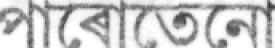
পাৰোতেনো
